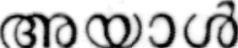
അയാള്‍
